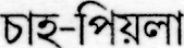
চাহ-পিয়লা
